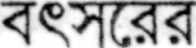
বৎসরের
